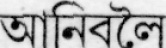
আনিবলৈ
